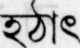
হঠাৎ
